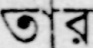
তার
